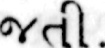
જતી.
